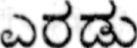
ಎರಡು
